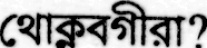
থোক্নবগীরা?
